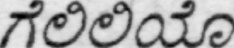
ಗೆಲಿಲಿಯೊ
